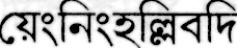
য়েংনিংহল্লিবদি
